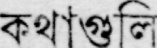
কথাগুলি
